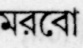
মরবো
